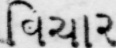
વિચાર
